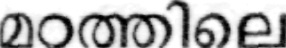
മഠത്തിലെ
